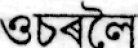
ওচৰলৈ
